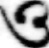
ও
